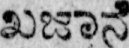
ಖಜಾನೆ
